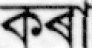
কৰা
